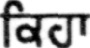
ਕਿਹਾ
